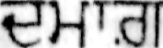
ਦਮਾਗ਼
